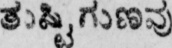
ತುಷ್ಟಿಗುಣವು
